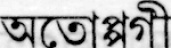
অতোপ্পগী
